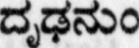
ದೃಢನುಂ
